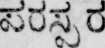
ಪರಸ್ಪರ
